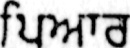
ਪਿਆਰ
